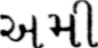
અમી
